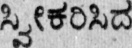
ಸ್ವೀಕರಿಸಿದ
